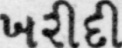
ખરીદી
